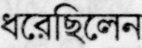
ধরেছিলেন
